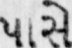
પાસે
